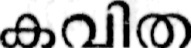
കവിത
